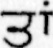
ਤਾਂ
